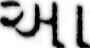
આ
